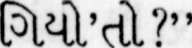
ગિયો'તો?"
